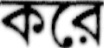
করে
